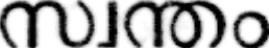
സ്വന്തം
